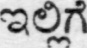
ಇಲ್ಲಿಗೆ
